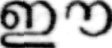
ഈ
